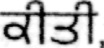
ਕੀਤੀ,
